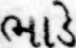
ભાડે
